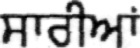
ਸਾਰੀਆਂ
